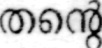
തന്റെ
